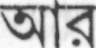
আর
